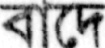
বাদে
